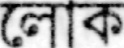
লোক
